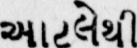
આટલેથી
